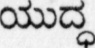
ಯುದ್ಧ
